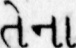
તેના
